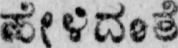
ಹೇಳಿದಂತೆ
